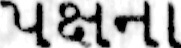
પક્ષના
